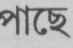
পাছে
